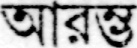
আরম্ভ
